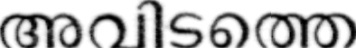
അവിടത്തെ
